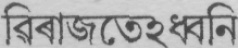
ৱিৰাজতেহধ্বনি
